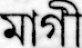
মাগী
